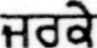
ਜਰਕੇ
